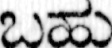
ಬಹು
